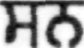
ਸਨ
